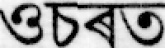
ওচৰত
